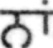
ਨਾਂ
